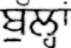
ਬੁੱਲ੍ਹਾਂ
